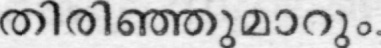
തിരിഞ്ഞുമാറും.
